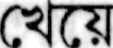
খেয়ে
